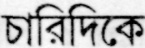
চারিদিকে
